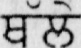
ਥੱਲੇ
